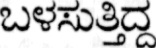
ಬಳಸುತ್ತಿದ್ದ
